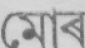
মোৰ
